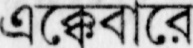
এক্কেবারে
